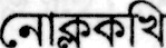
নোক্লকখি
